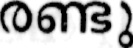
രണ്ടു
